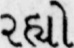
રહ્યો
